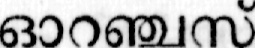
ഓറഞ്ചസ്
